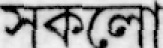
সকলো
